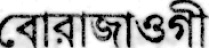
বোরাজাওগী
